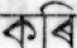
কৰি
